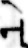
ને
